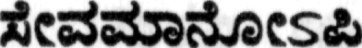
ಸೇವಮಾನೋsಪಿ
